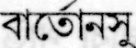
বার্তোনসু
